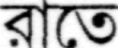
রাতে
